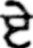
ਏ
